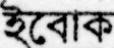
ইবোক
